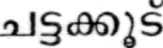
ചട്ടക്കൂട്
